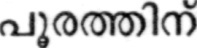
പൂരത്തിന്
